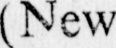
(New
